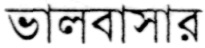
ভালবাসার
